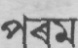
পৰম
